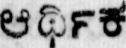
ಆರ್ಥಿಕ
